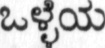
ಒಳ್ಳೆಯ
